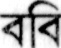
ববি
